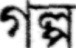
গল্প
